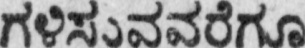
ಗಳಿಸುವವರೆಗೂ
